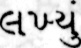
લખ્યું
